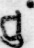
તું
